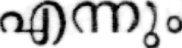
എന്നും
